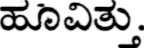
ಹೂವಿತ್ತು.
